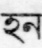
হন
